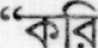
“করি
